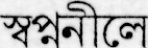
স্বপ্ননীলে
